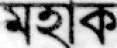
মহাক
